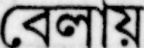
বেলায়
